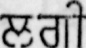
ਲਗੀ
